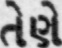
તેણે
